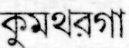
কুমথরগা
